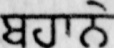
ਬਹਾਨੇ
